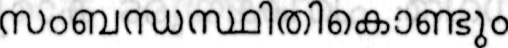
സംബന്ധസ്ഥിതികൊണ്ടും
